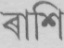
ৰাশি
